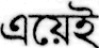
এয়েই
